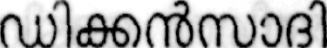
ഡിക്കന്‍സാദി
